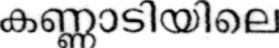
കണ്ണാടിയിലെ
